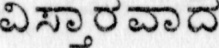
ವಿಸ್ತಾರವಾದ
